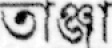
তাঞ্জা
